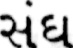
સંઘ
